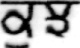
ਕੁਝ
